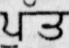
ਪੁੱਤ
